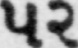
પર
